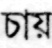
চায়
